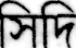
সিদি
